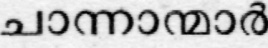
ചാന്നാന്മാര്‍
